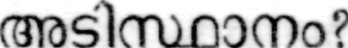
അടിസ്ഥാനം?
